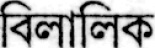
বিলালিক
